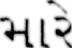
મારે
